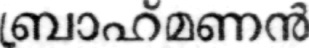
ബ്രാഹ്മണന്‍
